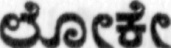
ಲೋಕೇ
